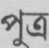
পুত্র
